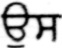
ਉਸ
